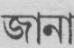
জানা
